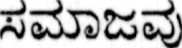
ಸಮಾಜವು
